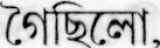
গৈছিলো,
